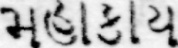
મહાકાય
